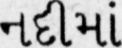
નદીમાં
